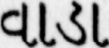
વાડા
